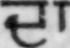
ਦਾ
